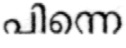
പിന്നെ
